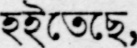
হইতেছে,
